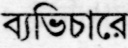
ব্যভিচারে
